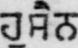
ਹੁਸੈਨ
